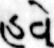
હવે
